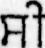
ਸੀ
